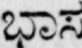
ಭಾಸ
